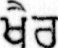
ਖੈਰ
